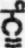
ਨੂੰ
